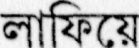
লাফিয়ে
